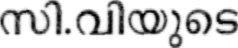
സി.വിയുടെ
